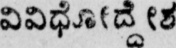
ವಿವಿಧೋದ್ದೇಶ
